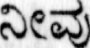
ನೀವು
